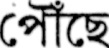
পৌঁছে
